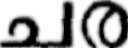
ചര
